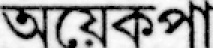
অয়েকপা
